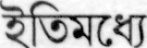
ইতিমধ্যে
